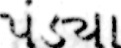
પંડ્યા
